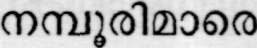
നമ്പൂരിമാരെ
